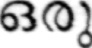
ഒരു
